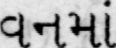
વનમાં
